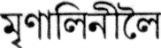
মৃণালিনীলৈ
